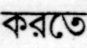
করতে
